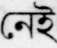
নেই
